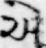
એ
